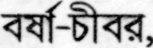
বর্ষা-চীবর,
